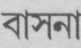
বাসনা
